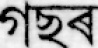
গছৰ
